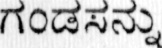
ಗಂಡಸನ್ನು
